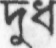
দুধ
